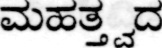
ಮಹತ್ತ್ವದ
